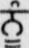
ਨੂੰ
